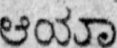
ಆಯಾ
